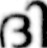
ദി
